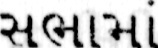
સભામાં
